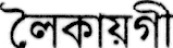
লৈকায়গী
